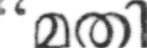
"മതി
